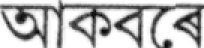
আকবৰে
